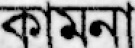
কামনা
